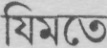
যিমতে
